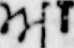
ਆ
